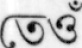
তেওঁ
